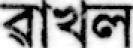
ৱাখল
